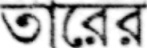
তারের
